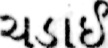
ચડાઈ
